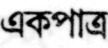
একপাত্র
